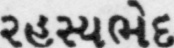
રહસ્યભેદ
